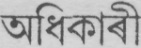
অধিকাৰী
